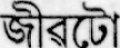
জীৱটো
